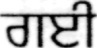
ਗਈ
